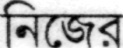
নিজের
